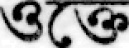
ওক্তে
